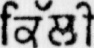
ਕਿੱਲੀ
